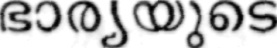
ഭാര്യയുടെ
